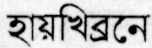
হায়খিব্রনে
